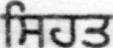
ਸਿਹਤ
